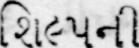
શિલ્પની
